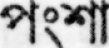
পংশা
